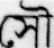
সৌ
